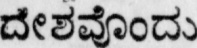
ದೇಶವೊಂದು
